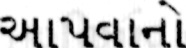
આપવાનો
